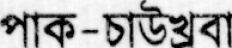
পাক-চাউখ্রবা
